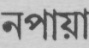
নপায়া
